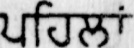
ਪਹਿਲਾਂ
